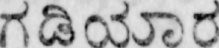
ಗಡಿಯಾರ
